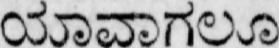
ಯಾವಾಗಲೂ
